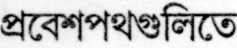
প্রবেশপথগুলিতে
